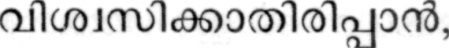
വിശ്വസിക്കാതിരിപ്പാന്‍,
